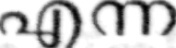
എന്ന
